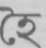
হৈ
